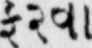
ફરવા
